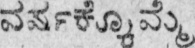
ವರ್ಷಕ್ಕೊಮ್ಮೆ
